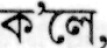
ক'লে,
